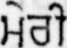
ਮੇਰੀ
